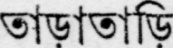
তাড়াতাড়ি
